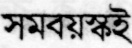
সমবয়স্কই
